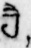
ਹੈ,
